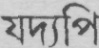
যদ্যপি
